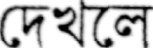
দেখলে
